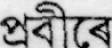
প্রবীৰে
